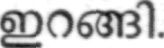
ഇറങ്ങി.
